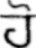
ਹੋ
